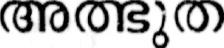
അത്ഭുത
